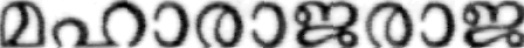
മഹാരാജരാജ
